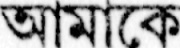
আমাকে
